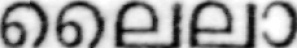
ലൈലാ
